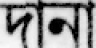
দানা
